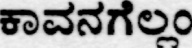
ಕಾವನಗೆಲ್ಲಂ
